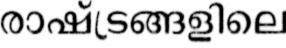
രാഷ്ട്രങ്ങളിലെ
